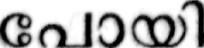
പോയി
